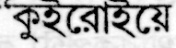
“কুইরোইয়ে
